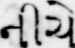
નીચે
